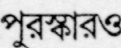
পুরস্কারও
